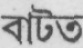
বাটত
